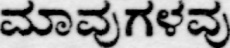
ಮಾವುಗಳವು
